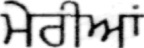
ਮੇਰੀਆਂ
